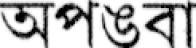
অপঙবা
